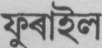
ফুৰাইল
